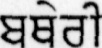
ਬਥੇਰੀ
